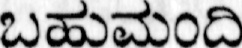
ಬಹುಮಂದಿ
